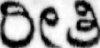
ರೀತಿ
